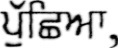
ਪੁੱਛਿਆ,
